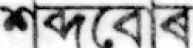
শব্দবোৰ
